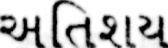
અતિશય
